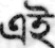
এই
